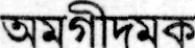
চাংয়েং
